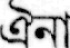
ঐনা
